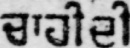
ਚਾਹੀਦੀ
